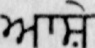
ਆਸ਼ੇ
